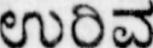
ಉರಿವ
